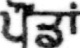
ਪੌਡਾਂ
